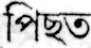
পিছত
